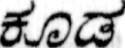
ಕೂಡ
